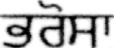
ਭਰੋਸਾ
